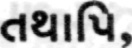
તથાપિ,
